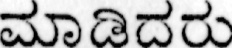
ಮಾಡಿದರು
